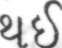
થઈ
